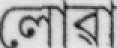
লোৱা
